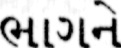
ભાગને
